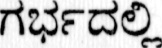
ಗರ್ಭದಲ್ಲಿ
